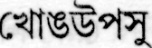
খোঙউপসু
